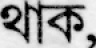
থাক,
